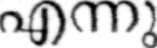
എന്നു
